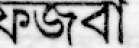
ফজবা
